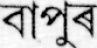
বাপুৰ
